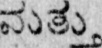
ಮತ್ತು
